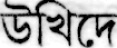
উখিদে
